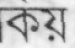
কিয়
